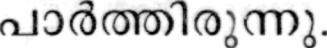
പാര്‍ത്തിരുന്നു.
